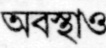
অবস্থাও
